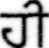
ਹੀ
